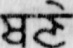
ਬਣੇ
